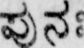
ಪುನಃ
